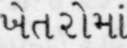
ખેતરોમાં
